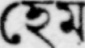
হেম
